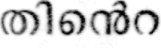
തിന്റെ
